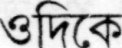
ওদিকে
